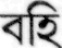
বহি
